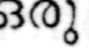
ഒരു
